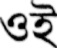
ওই
